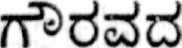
ಗೌರವದ
